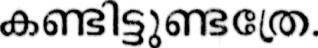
കണ്ടിട്ടുണ്ടത്രേ.
